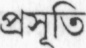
প্রসূতি
